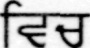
ਵਿਚ
